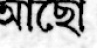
আছো
